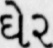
ઘરે
